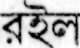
রইল
